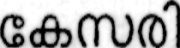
കേസരി
